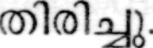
തിരിച്ചു.
